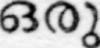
ഒരു
